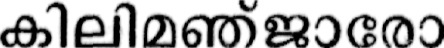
കിലിമഞ്ജാരോ
